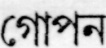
গোপন
